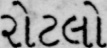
રોટલો
